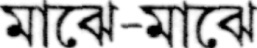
মাঝে-মাঝে
